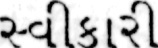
સ્વીકારી
